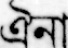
ঐনা
